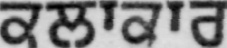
ਕਲਾਕਾਰ
